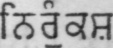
ਨਿਰੁੰਕਸ਼
